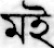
মই
